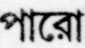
পারো
